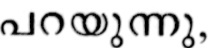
പറയുന്നു,
